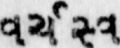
વર્ચસ્વ
